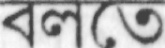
বলতে
